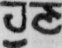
ਹੁਣ
